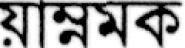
য়াম্নমক
